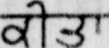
ਕੀਤਾ
